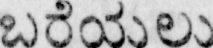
ಬರೆಯಲು
